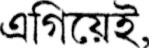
এগিয়েই,
